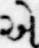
એ
